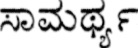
ಸಾಮರ್ಥ್ಯ
